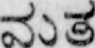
ಮತ
